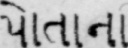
પોતાના
